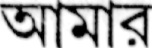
আমার
